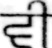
ਵੀ
